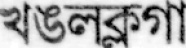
খঙলক্লগা
